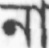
না
